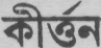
কীৰ্ত্তন
